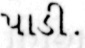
પાડી.
